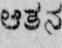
ಆತನ
